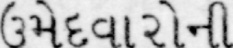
ઉમેદવારોની
